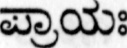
ಪ್ರಾಯಃ
